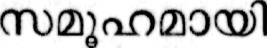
സമൂഹമായി
